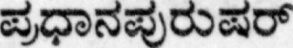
ಪ್ರಧಾನಪುರುಷರ್
